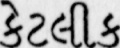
કેટલીક
